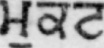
ਮੁਕਟ
